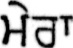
ਮੇਰਾ
